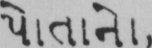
પોતાનો,
